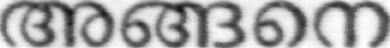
അങ്ങനെ
